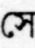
সে
